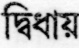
দ্বিধায়
